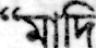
“মাদি
